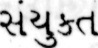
સંયુક્ત
